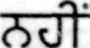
ਨਹੀਂ
